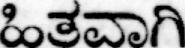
ಹಿತವಾಗಿ
